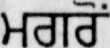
ਮਗਰੋਂ
